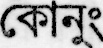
কোনুং
